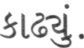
કાઢ્યું.
